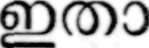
ഇതാ
